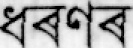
ধৰণৰ
